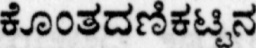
ಕೊಂತದಣಿಕಟ್ಟಿನ
